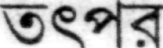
তৎপর
